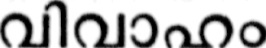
വിവാഹം
